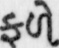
ફળે
